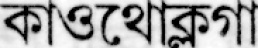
কাওথোক্লগা
